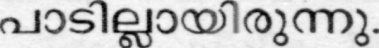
പാടില്ലായിരുന്നു.
